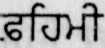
ਫ਼ਹਿਮੀ
